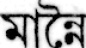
মান্নৈ
